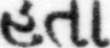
હતા
